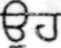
ਉਹ
